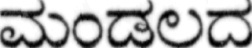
ಮಂಡಲದ
